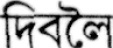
দিবলৈ
